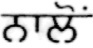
ਨਾਲੋਂ
